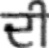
ਦੀ
